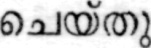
ചെയ്തു
